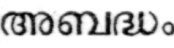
അബദ്ധം
